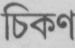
চিকণ
